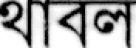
থাবল
